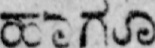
ಹಾಗೂ
